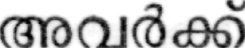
അവര്‍ക്ക്
